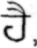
ਹੈ,
